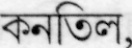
কনতিল,
